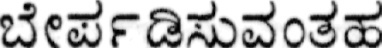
ಬೇರ್ಪಡಿಸುವಂತಹ
